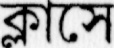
ক্লাসে
